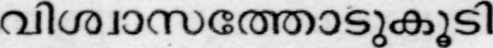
വിശ്വാസത്തോടുകൂടി
